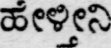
ಹೇಳ್ತೀನಿ
